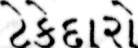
ટેકેદારો
